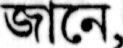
জানে,
